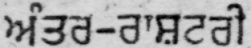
ਅੰਤਰ-ਰਾਸ਼ਟਰੀ
